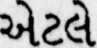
એટલે
